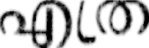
എത്ര
